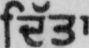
ਦਿੱਤਾ
